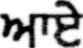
ਆਏ
